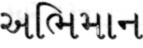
અભિમાન
